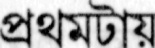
প্রথমটায়
